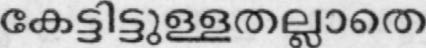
കേട്ടിട്ടുള്ളതല്ലാതെ
